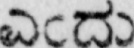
ಎಂದು
